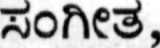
ಸಂಗೀತ,
